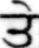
ਤੇ
